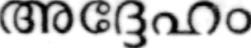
അദ്ദേഹം
